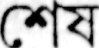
শেষ
